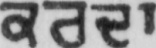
ਕਰਦਾ
